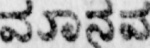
ಮಾನವ
